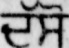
ਦੱਸੋ
